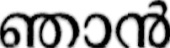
ഞാന്‍
